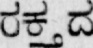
ರಕ್ತದ
